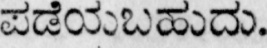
ಪಡೆಯಬಹುದು.
